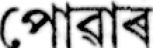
পোৱাৰ
